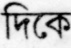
দিকে
